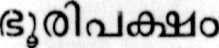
ഭൂരിപക്ഷം
